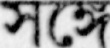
সঙ্গে
